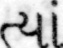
ત્યાં
